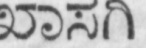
ಖಾಸಗಿ
